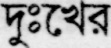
দুঃখের
